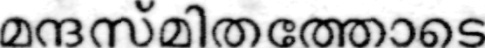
മന്ദസ്മിതത്തോടെ
